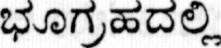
ಭೂಗ್ರಹದಲ್ಲಿ
